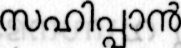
സഹിപ്പാന്‍
